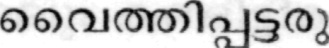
വൈത്തിപ്പട്ടരു
